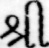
શ્રી
